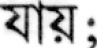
যায়;
